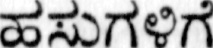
ಹಸುಗಳಿಗೆ
